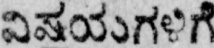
ವಿಷಯಗಳಿಗೆ
